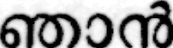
ഞാന്‍
